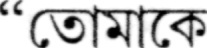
“তোমাকে
